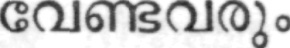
വേണ്ടവരും
